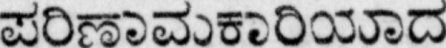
ಪರಿಣಾಮಕಾರಿಯಾದ
